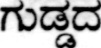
ಗುಡ್ಡದ
